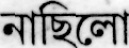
নাছিলো
